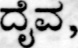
ದೈವ,
